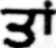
ਤਾਂ
